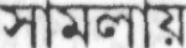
সামলায়
